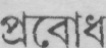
প্রবোধ
